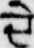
ਦੇ
